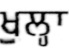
ਖੁਲ੍ਹਾ
